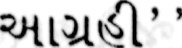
આગ્રહી"
